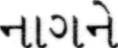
નાગને
